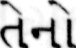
તેનો
